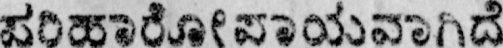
ಪರಿಹಾರೋಪಾಯವಾಗಿದೆ
